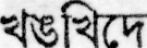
খঙখিদে
